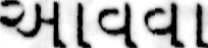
આવવા
